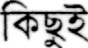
কিছুই
